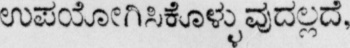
ಉಪಯೋಗಿಸಿಕೊಳ್ಳುವುದಲ್ಲದೆ,
